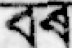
বৰ
